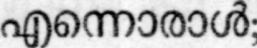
എന്നൊരാള്‍;
